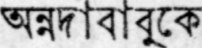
অন্নদাবাবুকে
